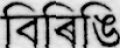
বিৰিঙি
